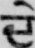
ਦੇ
